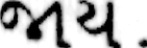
જાય.
